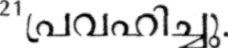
21പ്രവഹിച്ചു.
